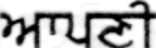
ਆਪਣੀ
